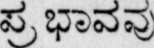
ಪ್ರಭಾವವು
